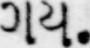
ગય.
